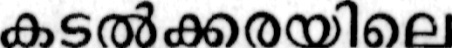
കടല്‍ക്കരയിലെ
